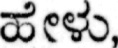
ಹೇಳು,
